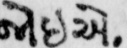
જોઈએ.
